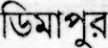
ডিমাপুর
